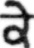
ਕੇ
